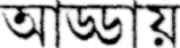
আড্ডায়
